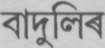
বাদুলিৰ
